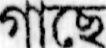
গাছে
